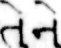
તેને
